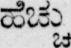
ಹೆಚ್ಚು
